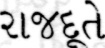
રાજદૂતે
